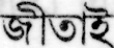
জীতাই
